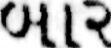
બાર
